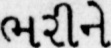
ભરીને
